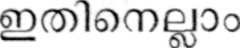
ഇതിനെല്ലാം
